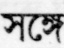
সঙ্গে
